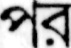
পর
